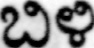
ಬಿಳಿ
